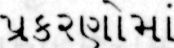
પ્રકરણોમાં
